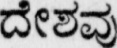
ದೇಶವು
